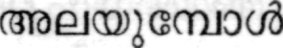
അലയുമ്പോള്‍
